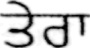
ਤੇਰਾ
